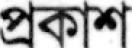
প্রকাশ
